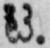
ಟ.
